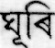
ঘূৰি
